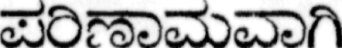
ಪರಿಣಾಮವಾಗಿ
